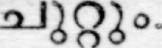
ചുറ്റും.
